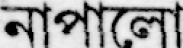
নাপালো
